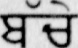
ਬੱਚੇ
